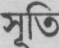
সূতি
